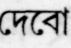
দেবো
